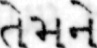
તેમને
